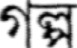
গল্প
